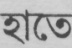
হাতে
